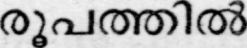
രൂപത്തില്‍
